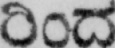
ರಿಂದ
